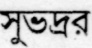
সুভদ্রর
